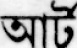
আর্ট
